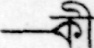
–কী
